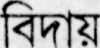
বিদায়
